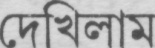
দেখিলাম
